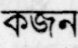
কজন
